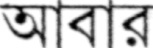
আবার
